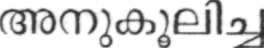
അനുകൂലിച്ച
